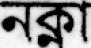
নক্না
